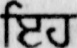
ਇਹ
